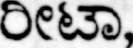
ರೀಟಾ,
